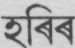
হৰিৰ
